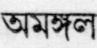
অমঙ্গল়
